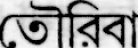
তৌরিবা
